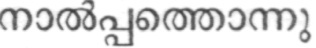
നാല്‍പ്പത്തൊന്നു
